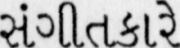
સંગીતકારે
